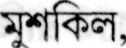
মুশকিল,
